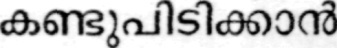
കണ്ടുപിടിക്കാന്‍
